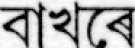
বাখৰে
